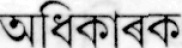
অধিকাৰক
